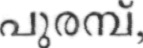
പുരമ്പ്,
